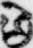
છે
